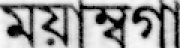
ময়াম্বগা
